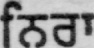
ਨਿਰਾ
